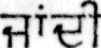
ਜਾਂਦੀ
